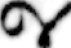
જ
